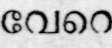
വേറെ
